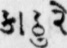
કાઠુરે
